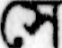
সে
